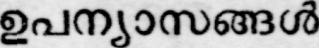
ഉപന്യാസങ്ങള്‍
